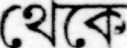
থেকে
